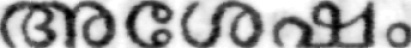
അശേഷം
